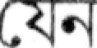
যেন
